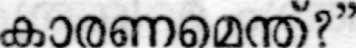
കാരണമെന്ത്?"
